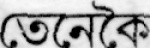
তেনেকৈ
